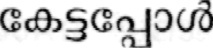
കേട്ടപ്പോള്‍
